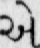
એ
